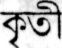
কৃতী
